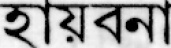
হায়বনা
